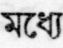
মধ্যে
